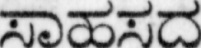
ಸಾಹಸದ
